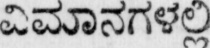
ವಿಮಾನಗಳಲ್ಲಿ
